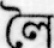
লৈ
